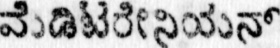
ಮೆಡಿಟರೇನಿಯನ್
